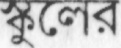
স্কুলের
